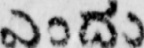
ಎಂದು
